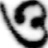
ও
